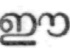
ഈ
